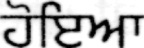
ਹੋਇਆ
